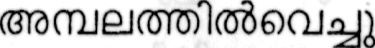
അമ്പലത്തില്‍വെച്ചു
